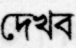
দেখব
